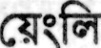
য়েংলি
